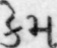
કેમ
